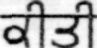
ਕੀਤੀ
